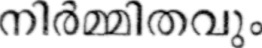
നിര്‍മ്മിതവും
